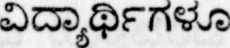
ವಿದ್ಯಾರ್ಥಿಗಳೂ
